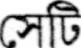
সেটি
